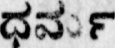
ಧರ್ಮ
